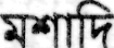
মশাদি
